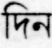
দিন
